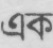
এক
